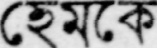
হেমকে
